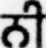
ਨੀ
